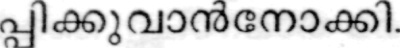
പ്പിക്കുവാന്‍നോക്കി.
